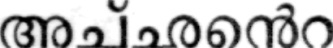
അച്ഛന്റെ
